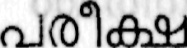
പരീക്ഷ
